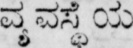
ವ್ಯವಸ್ಥೆಯ
